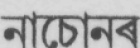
নাচোনৰ
